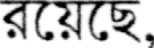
রয়েছে,
